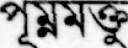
পূম্নমক্তু
